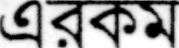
এরকম
